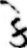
કે
